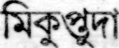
মিকুপ্তুদা
